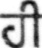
ਹੀ
